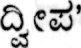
ದ್ವೀಪ'
